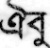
ঐবু
